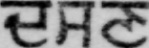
ਦਸਣ
